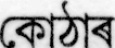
কোঠাৰ
